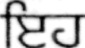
ਇਹ
